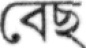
বেছ
